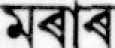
মৰাৰ
